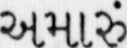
અમારું
